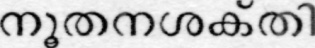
നൂതനശക്തി
